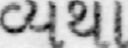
વ્યથા
